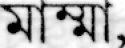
মাম্মা,
